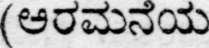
(ಅರಮನೆಯ
